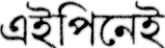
এইপিনেই
